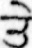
ਤੇ
